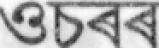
ওচৰৰ
